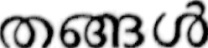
തങ്ങള്‍
